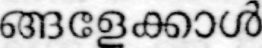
ങ്ങളേക്കാള്‍
